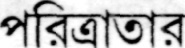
পরিত্রাতার
